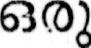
ഒരു
